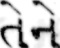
તેને
